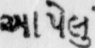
આપેલું
